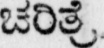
ಚರಿತ್ರೆ
